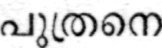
പുത്രനെ
